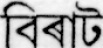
বিৰাট
